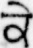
ਕੇ
